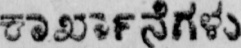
ಕಾರ್ಖಾನೆಗಳು
